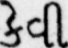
કેવી
